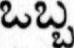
ಒಬ್ಬ
